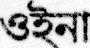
ওইনা
